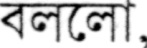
বললো,
